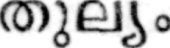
തുല്യം
